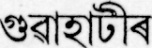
গুৱাহাটীৰ
